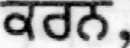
ਕਰਨ,
